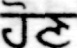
ਹੋਣ
